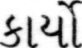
કાર્યો
